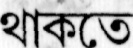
থাকতে
